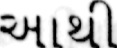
આથી
